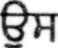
ਉਸ
